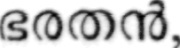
ഭരതന്‍,
